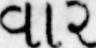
વાર
